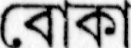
বোকা
